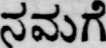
ನಮಗೆ
